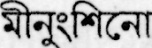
মীনুংশিনো
